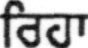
ਰਿਹਾ
